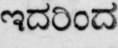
ಇದರಿಂದ
